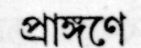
প্রাঙ্গণে
